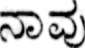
ನಾವು
